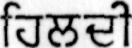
ਹਿਲਦੀ
